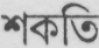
শকতি
